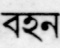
বহন
